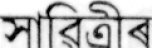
সাৱিত্রীৰ
